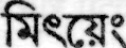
মিৎয়েং
